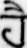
ਹੈ
